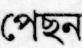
পেছন
